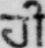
ਹੀ
